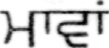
ਮਾਵਾਂ
